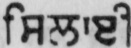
ਸਿਲਾਈ
